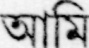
আমি
